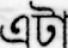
এটা
